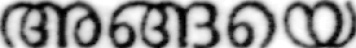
അങ്ങയെ
